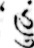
'હું
